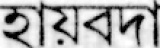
হায়বদা
